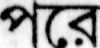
পরে
